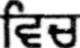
ਵਿਚ
